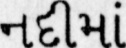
નદીમાં
